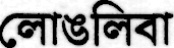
লোঙলিবা
